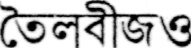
তৈলবীজও
